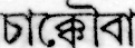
চাক্কৌবা
